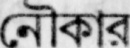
নৌকার
